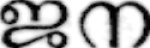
ജന
